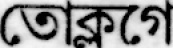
তোক্লগে
